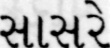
સાસરે
